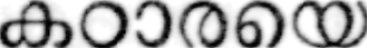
കഠാരയെ
